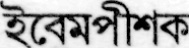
ইবেমপীশক
